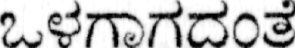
ಒಳಗಾಗದಂತೆ
